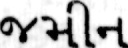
જમીન
